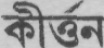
কীৰ্ত্তন
